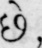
છે,
